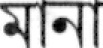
মানা
